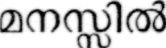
മനസ്സില്‍
